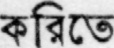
করিতে
